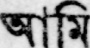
আমি
